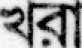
খরা
